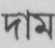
দাম
